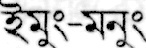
ইমুং-মনুং
